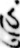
હું
